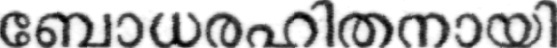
ബോധരഹിതനായി
